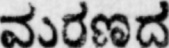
ಮರಣದ
